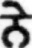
ਨੇ
